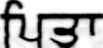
ਪਿਤਾ
